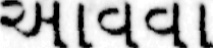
આવવા
